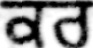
ਕਰ
